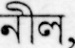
নীল,
